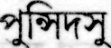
পুন্সিদসু
